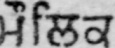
ਮੌਲਿਕ
